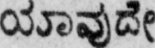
ಯಾವುದೇ
